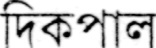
দিকপাল
